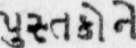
પુસ્તકોને
